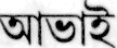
আভাই
